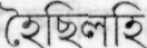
হৈছিলহি
